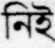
নিই
